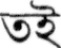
তই
